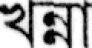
খন্না
